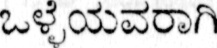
ಒಳ್ಳೆಯವರಾಗಿ
